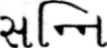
સન્નિ
